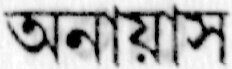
অনায়াস
